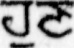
ਹੁਣ
